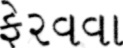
ફેરવવા
